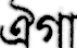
ঐগা
